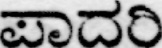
ಪಾದರಿ
